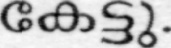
കേട്ടു.
